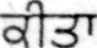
ਕੀਤਾ
